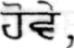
ਹੋਵੇ,
